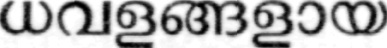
ധവളങ്ങളായ
